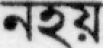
নহয়
